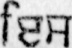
ਇਸ
